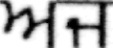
ਅਜ
